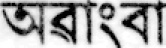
অৱাংবা
